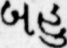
બહુ
